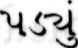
પડ્યું
